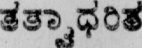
ತತ್ವಾಧರಿತ
